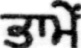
ਭਾਮੇਂ
